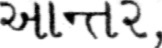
આન્તર,
